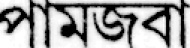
পামজবা
